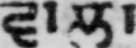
ਵਾਲਾ
